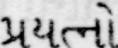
પ્રયત્નો
